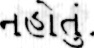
નહોતું.
